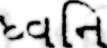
ધ્વનિ
